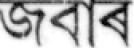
জবাৰ
